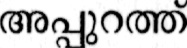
അപ്പുറത്ത്
